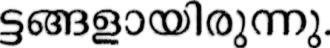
ട്ടങ്ങളായിരുന്നു.
